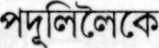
পদূলিলৈকে
